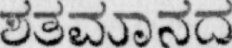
ಶತಮಾನದ
